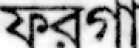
ফরগা
